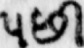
પછી
